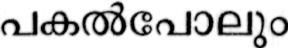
പകല്‍പോലും
